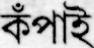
কঁপাই
